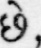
છે,
